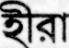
হীরা
